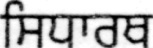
ਸਿਧਾਰਥ
